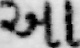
આ
